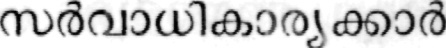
സര്‍വാധികാര്യക്കാര്‍
